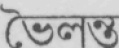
ভৈলন্ত
